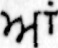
ਆਂ
